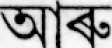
আৰু
